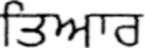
ਤਿਆਰ
